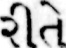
રીતે
